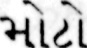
મોટો
